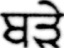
ਬੜੇ
